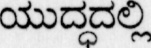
ಯುದ್ಧದಲ್ಲಿ
